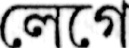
লেগে
